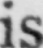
is
